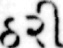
ઠરી
